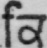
ਕਿ
